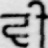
ਵੀ
